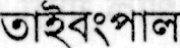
তাইবংপাল
